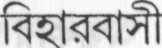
বিহারবাসী
